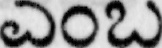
ಎಂಬ
